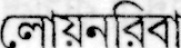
লোয়নরিবা
